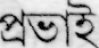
প্রভাই
